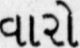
વારો
